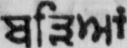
ਬੜਿਆਂ
